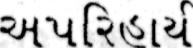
અપરિહાર્ય
